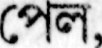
পেল,
